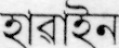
হাৱাইন
